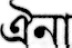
ঐনা
